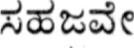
ಸಹಜವೇ
